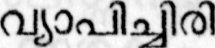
വ്യാപിച്ചിരി
